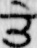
ਤੇ
